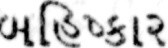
બહિષ્કાર
